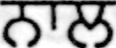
ਨਾਲ
